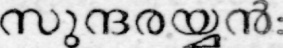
സുന്ദരയ്യന്‍:
